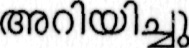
അറിയിച്ചു
